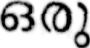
ഒരു
